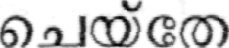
ചെയ്തേ
